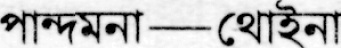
পান্দমনা-থোইনা
